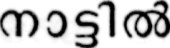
നാട്ടില്‍
